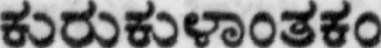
ಕುರುಕುಳಾಂತಕಂ
